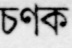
চণক
